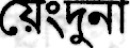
য়েংদুনা
